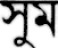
সুম
